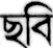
ছবি
